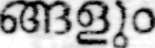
ങ്ങളും
